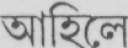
আহিলে
